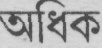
অধিক
